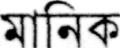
মানিক
